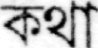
কথা
